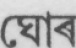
ঘোৰ
